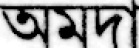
অমদা
